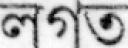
লগত
